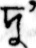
দু'
